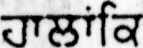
ਹਾਲਾਂਕਿ
